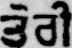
ਤੋਰੀ
